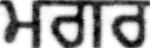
ਮਗਰ
